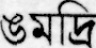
ঙমদ্রি
